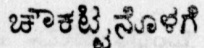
ಚೌಕಟ್ಟಿನೊಳಗೆ
